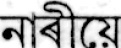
নাৰীয়ে
